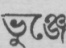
ভুঞ্জে
